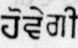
ਹੋਵੇਗੀ
